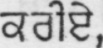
ਕਰੀਏ,
